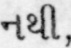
નથી,
